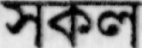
সকল
